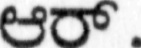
ಆರ್.
